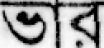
ভার
